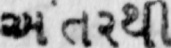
અંતરથી
